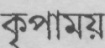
কৃপাময়
